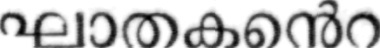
ഘാതകന്റെ
